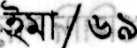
ইমা/৬৯
